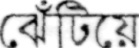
ঝেঁটিয়ে
